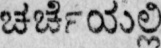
ಚರ್ಚೆಯಲ್ಲಿ
